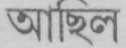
আছিল
